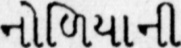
નોળિયાની
